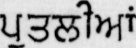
ਪੁਤਲੀਆਂ
